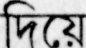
দিয়ে
